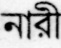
নারী
